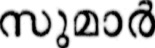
സുമാര്‍
